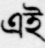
এই
